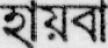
হায়বা
